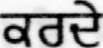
ਕਰਦੇ
